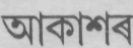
আকাশৰ
